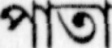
পাতা
